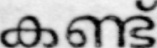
കണ്ട്
